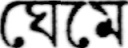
ঘেমে
